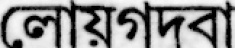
লোয়গদবা
